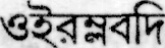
ওইরম্লবদি
